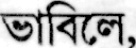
ভাবিলে,
